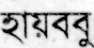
হায়বদু
